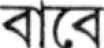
বাবে
